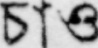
চাও
